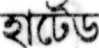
হার্টেড
